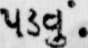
પડવું.
